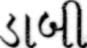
ડાબી
